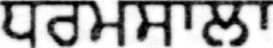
ਧਰਮਸਾਲਾ
